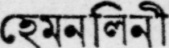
হেমনলিনী
